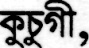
কুচুগী,
